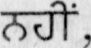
ਨਹੀਂ,
